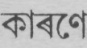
কাৰণে
